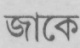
জাকে
